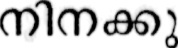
നിനക്കു
